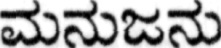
ಮನುಜನು
